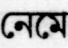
নেমে
